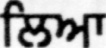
ਲਿਆ
